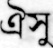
ঐসু
